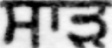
ਸਾੜ
